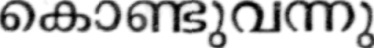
കൊണ്ടുവന്നു
